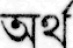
অর্থ
